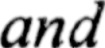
and
